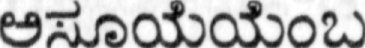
ಅಸೂಯೆಯೆ೦ಬ
